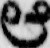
ಆ
